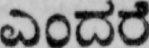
ಎಂದರೆ
